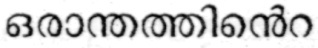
ഒരാന്തത്തിന്റെ
